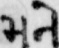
મને
